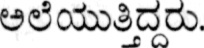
ಅಲೆಯುತ್ತಿದ್ದರು.
